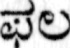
ಫಲ
